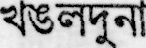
খঙলদুনা
